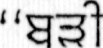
''ਬੜੀ
